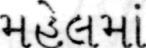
મહેલમાં
